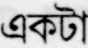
একটা
